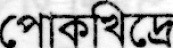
পোকখিদ্রে
